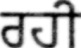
ਰਹੀ
